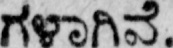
ಗಳಾಗಿವೆ.
